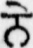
ਨੇ
